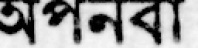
অপনবা
